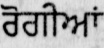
ਰੋਗੀਆਂ
